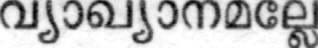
വ്യാഖ്യാനമല്ലേ
